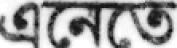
এনেতে
